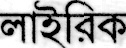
লাইরিক
